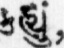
કહ્યું,
